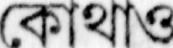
কোথাও
